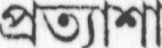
প্রত্যাশা
